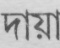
দায়া
